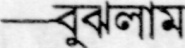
–বুঝলাম
